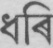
ধৰি
